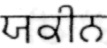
ਯਕੀਨ
